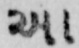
આ
